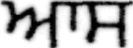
ਆਸ
